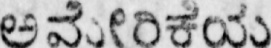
ಅಮೇರಿಕೆಯ
